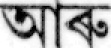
আৰু
